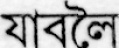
যাবলৈ
